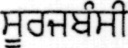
ਸੂਰਜਬੰਸੀ
